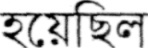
হয়েছিল
